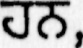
ਹਨ,
